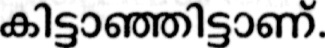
കിട്ടാഞ്ഞിട്ടാണ്.
